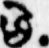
છે.
